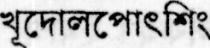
খূদোলপোৎশিং
